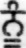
ਨੂੰ
